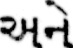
અને
